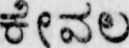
ಕೇವಲ
